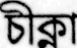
চীক্না
